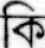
কি
